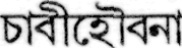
চাবীহৌবনা
